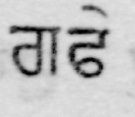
ਗਫੇ
